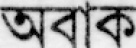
অবাক
